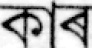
কাৰ
